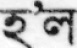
হ'ল
